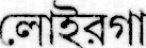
লোইরগা
